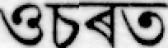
ওচৰত
